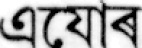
এযোৰ
